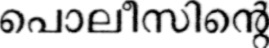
പൊലീസിന്റെ
